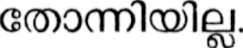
തോന്നിയില്ല.
